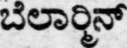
ಬೆಲಾರ್‍ಮಿನ್
